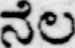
ನೆಲ
